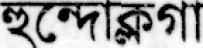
হুন্দোক্লগা
